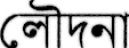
লৌদনা
